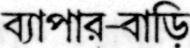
ব্যাপার-বাড়ি
